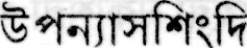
উপন্যাসশিংদি
